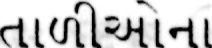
તાળીઓના
